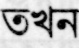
তখন
